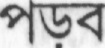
পড়ব
